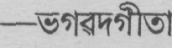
-ভগৱদগীতা
